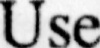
Use
